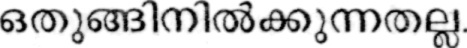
ഒതുങ്ങിനില്‍ക്കുന്നതല്ല.
